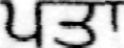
ਪਤਾ
